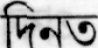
দিনত
